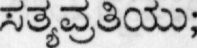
ಸತ್ಯವ್ರತಿಯು;
